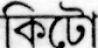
কিটো
